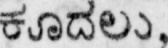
ಕೂದಲು,
